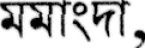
মমাংদা,
